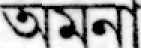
অমনা
